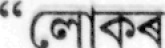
"লোকৰ
